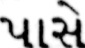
પાસે
